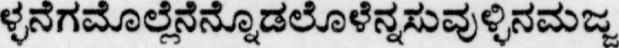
ಳ್ಳನೆಗಮೊಲ್ಲೆನೆನ್ನೊಡಲೊಳೆನ್ನಸುವುಳ್ಳಿನಮಜ್ಜ
